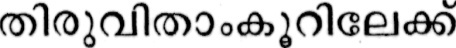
തിരുവിതാംകൂറിലേക്ക്
